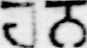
ਹਨ
